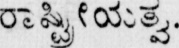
ರಾಷ್ಟ್ರೀಯತ್ವ.
